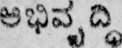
ಅಭಿವೃದ್ಧಿ
